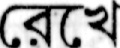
রেখে
